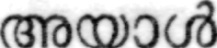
അയാള്‍
